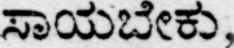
ಸಾಯಬೇಕು,
